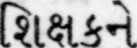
શિક્ષકને
